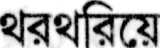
থরথরিয়ে
